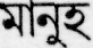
মানুহ
